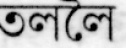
তললৈ
